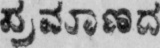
ಪ್ರಮಾಣದ
